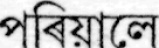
পৰিয়ালে
